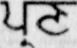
ਪ੍ਰਣ
